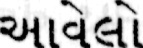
આવેલો
